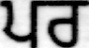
ਪਰ
